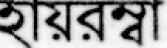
হায়রম্বা
